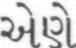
એણે
